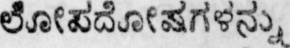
ಲೋಪದೋಷಗಳನ್ನು
